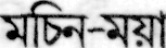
মচিন-ময়া
